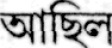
আছিল
